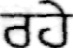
ਰਹੇ
